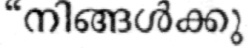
“നിങ്ങള്‍ക്കു
